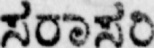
ಸರಾಸರಿ
